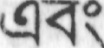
এবং
